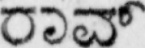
ರಾವ್
